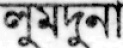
লুমদুনা
